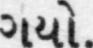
ગયો.
